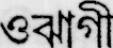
ওঝাগী
